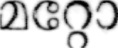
മറ്റോ
